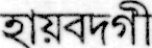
হায়বদগী
